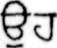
ਉਹ
